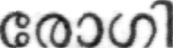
രോഗി
